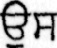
ਉਸ
